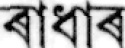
ৰাধাৰ
